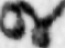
જ
